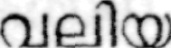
വലിയ
